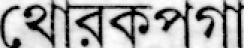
থোরকপগা
